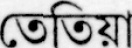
তেতিয়া
